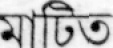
মাটিত
